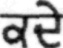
ਕਦੇ
